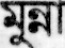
মুন্না
